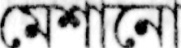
মেশানো
